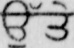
ਉੱਤੇ
